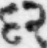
દર
